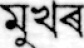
মুখৰ
